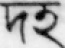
দহ
